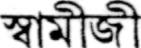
স্বামীজী
